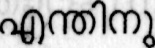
എന്തിനു
